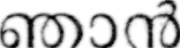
ഞാന്‍
